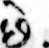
છે.
